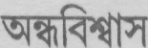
অন্ধবিশ্বাস
